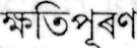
ক্ষতিপূৰণ
